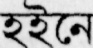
হইনে
